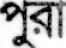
পুরা
